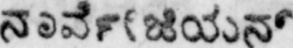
ನಾರ್ವೇಜಿಯನ್
